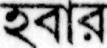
হবার
